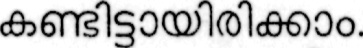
കണ്ടിട്ടായിരിക്കാം.
